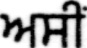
ਅਸੀਂ
